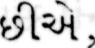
છીએ,
